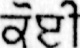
ਕੋਈ
